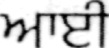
ਆਈ
